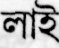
লাই
